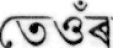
তেওঁৰ
